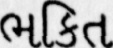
ભક્તિ
